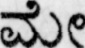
ಮೇ
